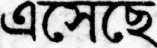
এসেছে
